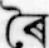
ৰৈ
